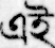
এই
